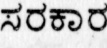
ಸರಕಾರ
